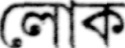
লোক
